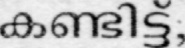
കണ്ടിട്ട്,
